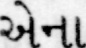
એના
